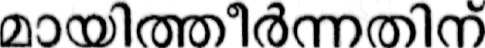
മായിത്തീര്‍ന്നതിന്
